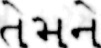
તેમને
